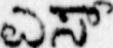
ಎಸ್
